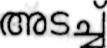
അടച്ച്
